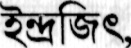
ইন্দ্রজিৎ,
